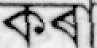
কৰা
